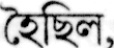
হৈছিল,
